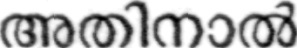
അതിനാല്‍
